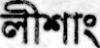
লীশাং
